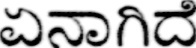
ಏನಾಗಿದೆ
